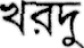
খরদু
